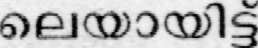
ലെയായിട്ട്
